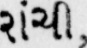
રાંચી,
